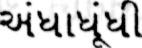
અંધાધૂંધી
